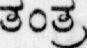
ತಂತ್ರ
